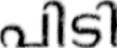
പിടി
